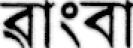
ৱাংবা
